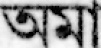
অমা
